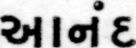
આનંદ
